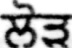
ਲੋੜ
